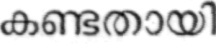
കണ്ടതായി
